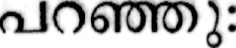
പറഞ്ഞു:
